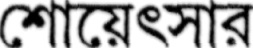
শোয়েৎসার
